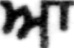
ਆ
